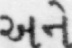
અને
